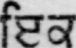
ਇਕ
